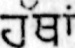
ਹੱਥਾਂ
